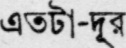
এতটা-দূর
